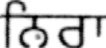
ਨਿਰਾ
